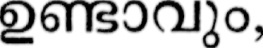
ഉണ്ടാവും,
